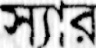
স্যার
